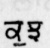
ਕੁਝ
